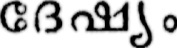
ദേഷ്യം
